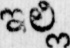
ಇಲ್ಲಿ
